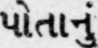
પોતાનું
